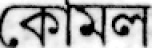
কোমল
